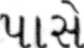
પાસે
